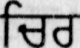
ਚਿਰ
